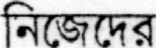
নিজেদের
